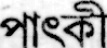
পাৎকী
